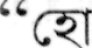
“হো
